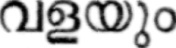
വളയും
